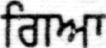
ਗਿਆ
